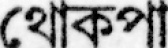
থোকপা
